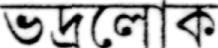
ভদ্রলোক
